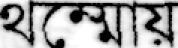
থম্মোয়
